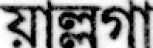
য়াল্লগা
